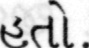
હતો.
